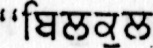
''ਬਿਲਕੁਲ
